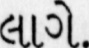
લાગે.
